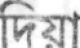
দিয়া
